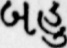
બહુ
